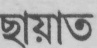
ছায়াত
